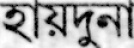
হায়দুনা
